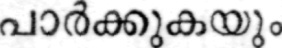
പാര്‍ക്കുകയും
